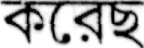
করেছ
